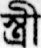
স্ত্রী
